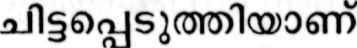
ചിട്ടപ്പെടുത്തിയാണ്
